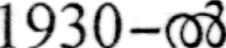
1930-ല്‍
